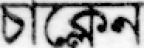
চাক্লেন
